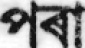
পৰা
